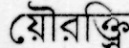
য়ৌরক্ত্রি
